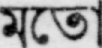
মতো
